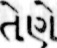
તેણે
